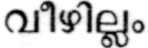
വീഴില്ലം
